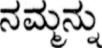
ನಮ್ಮನ್ನು
